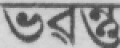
ভৱন্তু
